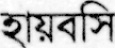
হায়বসি
